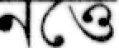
নত্তে
